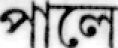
পালে
